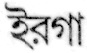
ইরগা
